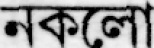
নকলো
